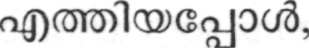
എത്തിയപ്പോള്‍,
